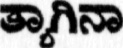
ತ್ಯಾಗಿನಾ
